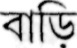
বাড়ি
